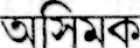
অসিমক
